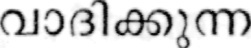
വാദിക്കുന്ന
